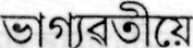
ভাগ্যৱতীয়ে
